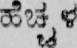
ಹೆಚ್ಚಳ
